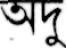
অদু
